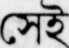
সেই
